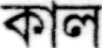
কাল
